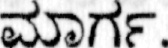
ಮಾರ್ಗ.
